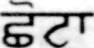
ਛੋਟਾ
